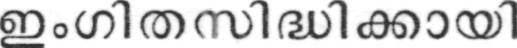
ഇംഗിതസിദ്ധിക്കായി
